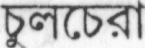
চুলচেরা
